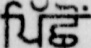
ਪਿੱਛੋਂ
